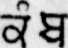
ਕੰਬ
